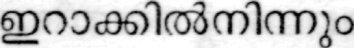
ഇറാക്കില്‍നിന്നും
